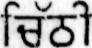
ਚਿੱਠੀ
